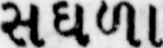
સઘળા
